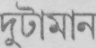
দুটামান
